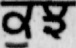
ਕੁਝ
